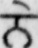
ਨੇ
